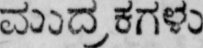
ಮುದ್ರಕಗಳು
